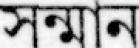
সন্মান
